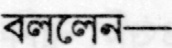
বললেন–
